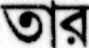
তার
